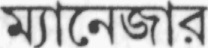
ম্যানেজার
